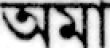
অমা
